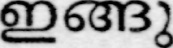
ഇങ്ങു
